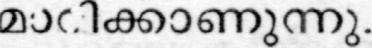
മാറിക്കാണുന്നു.
